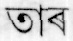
তাৰ
